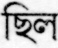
ছিল
